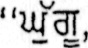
''ਘੁੱਗੂ,
